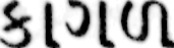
કાગળ
